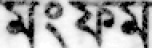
মংফম
